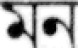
মন
